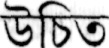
উচিত
